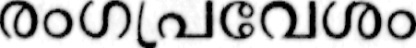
രംഗപ്രവേശം
